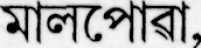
মালপোৱা,
